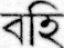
বহি
